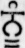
ਨੂੰ
